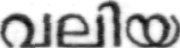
വലിയ
